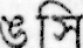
ঙসি
